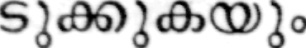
ടുക്കുകയും
